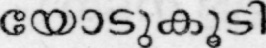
യോടുകൂടി
